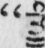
''ਤੂੰ
